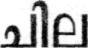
ചില
